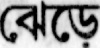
ঝেড়ে
